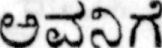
ಅವನಿಗೆ
